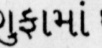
ગુફામાં
